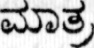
ಮಾತ್ರ
